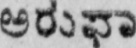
ಅರುಫಾ
